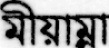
মীয়াম্না
